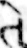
તે
